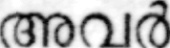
അവര്‍
